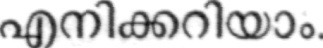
എനിക്കറിയാം.
